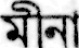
নীনা
